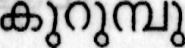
കുറുമ്പു
